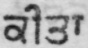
ਕੀਤਾ
